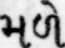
મળે
